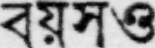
বয়সও
